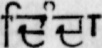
ਦਿੰਦਾ
